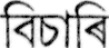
বিচাৰি
